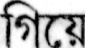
গিয়ে
